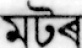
মটৰ
